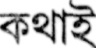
কথাই
